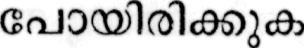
പോയിരിക്കുക
